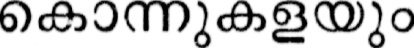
കൊന്നുകളയും
